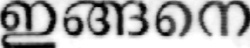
ഇങ്ങനെ
